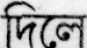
দিলে
